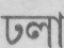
ঢলা
